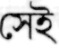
সেই
